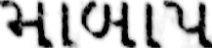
માબાપ
